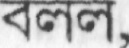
বলল,
